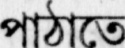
পাঠাতে
